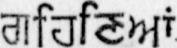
ਗਹਿਣਿਆਂ
